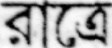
রাত্রে
